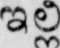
ಇಲ್ಲಿ
